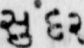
સુંદર
